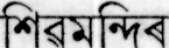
শিৱমন্দিৰ
